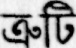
ত্রুটি
